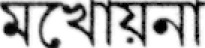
মখোয়না
